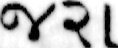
જરા
